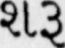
શરૂ
